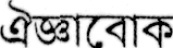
ঐজ্ঞাবোক
